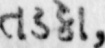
તડકો,
